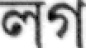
লগ
